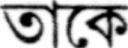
তাকে
